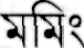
মমিং
